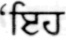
'ਇਹ
